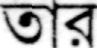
তার
